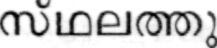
സ്ഥലത്തു
